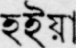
হইয়া
